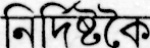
নিৰ্দিষ্টকৈ
